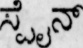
ಸ್ಪೈನ್
